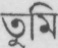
তুমি
